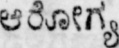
ಆರೋಗ್ಯ
